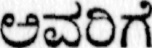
ಅವರಿಗೆ
